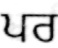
ਪਰ
